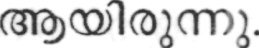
ആയിരുന്നു.
